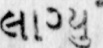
લાગ્યું
